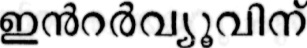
ഇന്റര്‍വ്യൂവിന്
